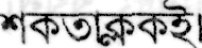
শকতাক্লকই।
